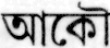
আকৌ
